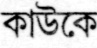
কাউকে
